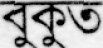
বুকুত
